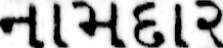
નામદાર
